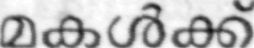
മകള്‍ക്ക്
